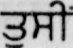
ਤੁਸੀਂ
